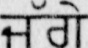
ਜੱਗੇ
